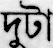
দুটা
